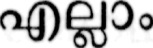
എല്ലാം
